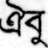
ঐবু
